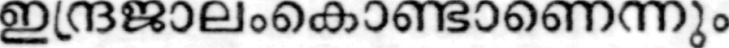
ഇന്ദ്രജാലംകൊണ്ടാണെന്നും
